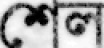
শেল
